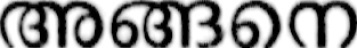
അങ്ങനെ
